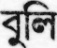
বুলি
